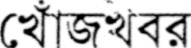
খোঁজখবর
